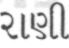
રાણી
